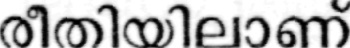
രീതിയിലാണ്
